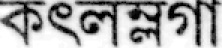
কৎলম্লগা
